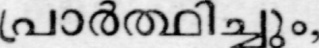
പ്രാര്‍ത്ഥിച്ചും,
